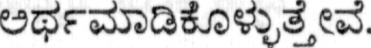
ಅರ್ಥಮಾಡಿಕೊಳ್ಳುತ್ತೇವೆ.
